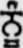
ਨੂੰ
